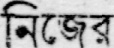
নিজের
